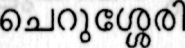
ചെറുശ്ശേരി
